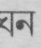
ঘন
